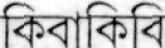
কিবাকিবি
